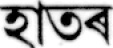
হাতৰ
